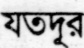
যতদূর
